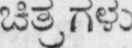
ಚಿತ್ರಗಳು
